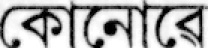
কোনোৱে
